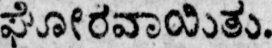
ಘೋರವಾಯಿತು.
